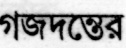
গজদন্তের
